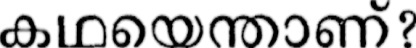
കഥയെന്താണ്?
